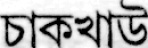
চাকখাউ
